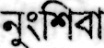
নুংশিবা
